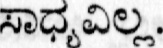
ಸಾಧ್ಯವಿಲ್ಲ.
